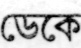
ডেকে
